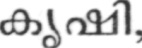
കൃഷി,
